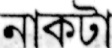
নাকটা
